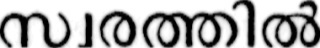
സ്വരത്തില്‍
